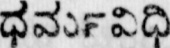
ಧರ್ಮವಿಧಿ
